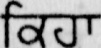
ਕਿਹਾ
